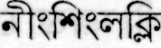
নীংশিংলক্লি
